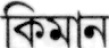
কিমান
